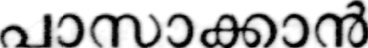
പാസാക്കാന്‍
